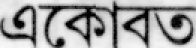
একোবত
